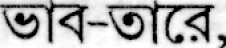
ভাব-তারে,
